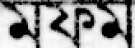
মফম
